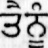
ਤੈਨੂੰ
